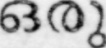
ഒരു
